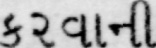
કરવાની
